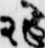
રહે
